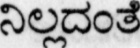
ನಿಲ್ಲದಂತೆ
